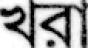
খরা
